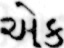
એક
